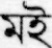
মই
